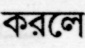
করলে
